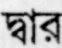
দ্বার
